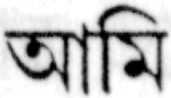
আমি
